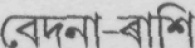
বেদনা-ৰাশি
